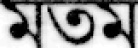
মতম
